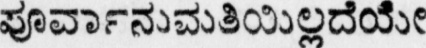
ಪೂರ್ವಾನುಮತಿಯಿಲ್ಲದೆಯೇ
